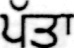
ਪੱਤਾ
